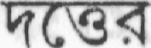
দত্তের
